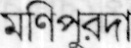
মণিপুরদা
